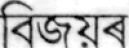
বিজয়ৰ
